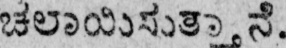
ಚಲಾಯಿಸುತ್ತಾನೆ.
